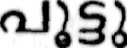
പൂട്ടു
